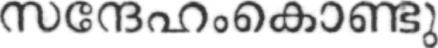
സന്ദേഹംകൊണ്ടു
